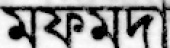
মফমদা
